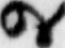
જ
